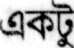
একটু
